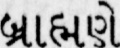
બ્રાહ્મણે
